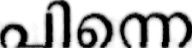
പിന്നെ
